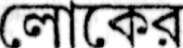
লোকের
